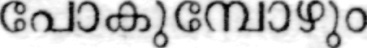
പോകുമ്പോഴും
